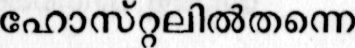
ഹോസ്റ്റലില്‍തന്നെ
